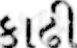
કાઢી
